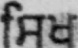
ਸਿਖ
